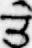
ਤੇ
